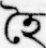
হৈ
